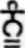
ਨੂੰ
